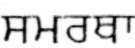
ਸਮਰਥਾ
